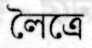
লৈত্রে
